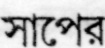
সাপের
